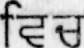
ਵਿਚ
